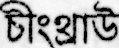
চীংথ্রাউ
